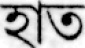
হাত
